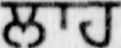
ਲਾਹ
